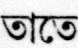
তাতে
